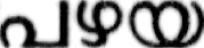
പഴയ
